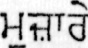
ਮੁਜ਼ਾਰੇ
